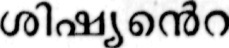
ശിഷ്യന്റെ
